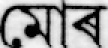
মোৰ
